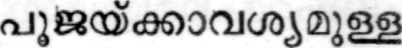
പൂജയ്ക്കാവശ്യമുള്ള
